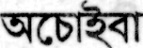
অচোইবা
